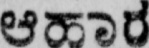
ಆಹಾರ
